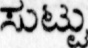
ಸುಟ್ಟು
